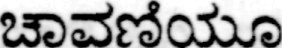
ಚಾವಣಿಯೂ
